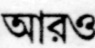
আরও
